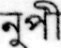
নুপী
